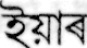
ইয়াৰ
